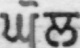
ਘੋਲ
